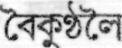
বৈকুণ্ঠলৈ
